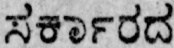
ಸರ್ಕಾರದ
